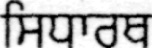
ਸਿਧਾਰਥ
